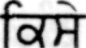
ਕਿਸੇ
